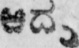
ಅದ್ರು
